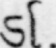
ર્ડા.
